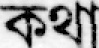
কথা
